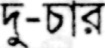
দু-চার
